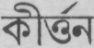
কীৰ্ত্তন
